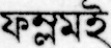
ফম্লমই
